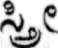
ಸ್ತ್ರೀ
